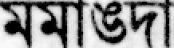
মমাঙদা
